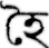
হৈ
